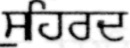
ਸੁਹਿਰਦ
